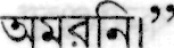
অমরনি।”
